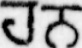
ਹਨ
